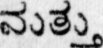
ಮತ್ತು
